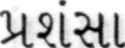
પ્રશંસા
